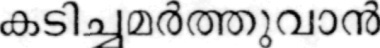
കടിച്ചമര്‍ത്തുവാന്‍
